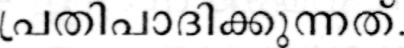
പ്രതിപാദിക്കുന്നത്.
